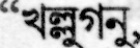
“খল্লুগনু,
